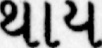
થાય
